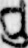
દોષ
